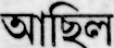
আছিল
